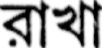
রাখা
